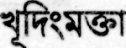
খূদিংমক্তা
